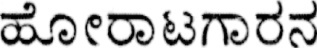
ಹೋರಾಟಗಾರನ
